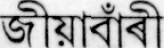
জীয়াবাঁৰী
